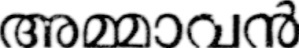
അമ്മാവന്‍
